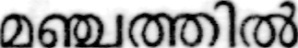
മഞ്ചത്തില്‍
